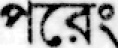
পরেং
